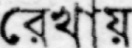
রেখায়
